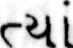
ત્યાં
